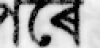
পৰে
